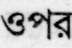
ওপর
